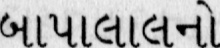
બાપાલાલનો
